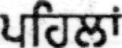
ਪਹਿਲਾਂ
